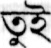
তুই
